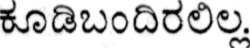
ಕೂಡಿಬಂದಿರಲಿಲ್ಲ.
